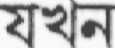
যখন
